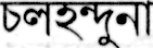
চলহন্দুনা
